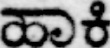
ಹಾಕಿ
